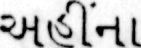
અહીંના
